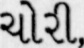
ચોરી,
